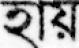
হায়
